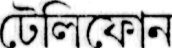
টেলিফোন
